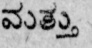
ಮತ್ತು
